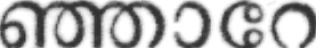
ഞ്ഞാറേ
